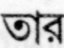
তার
